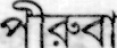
পীরুবা
